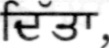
ਦਿੱਤਾ,
